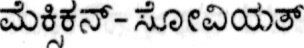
ಮೆಕ್ಸಿಕನ್-ಸೋವಿಯತ್
